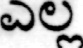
ಎಲ್ಲ
